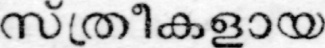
സ്ത്രീകളായ
